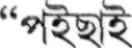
"পইছাই
